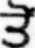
ਤੋਂ
